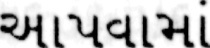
આપવામાં
